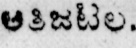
ಅತಿಜಟಿಲ.
